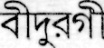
বীদুরগী
